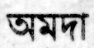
অমদা
